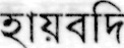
হায়বদি
